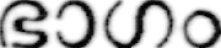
ഭാഗം
